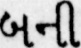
બની
